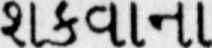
શકવાના
